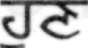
ਹੁਣ
